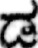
ಡ
